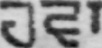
ਹਵਾ
